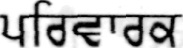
ਪਰਿਵਾਰਕ
